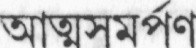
আত্মসমর্পণ
